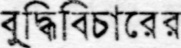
বুদ্ধিবিচারের
